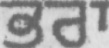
ਭਰਾ
